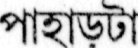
পাহাড়টা
